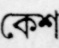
কেশ
